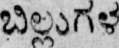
ಬಿಲ್ಲುಗಳ
